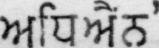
ਅਧਿਐਨ'
